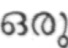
ഒരു
